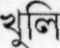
খুলি
